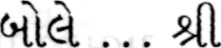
બોલે...શ્રી
